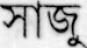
সাজু
